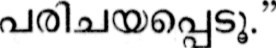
പരിചയപ്പെടൂ.”
